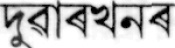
দুৱাৰখনৰ
